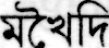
মখৈদি
